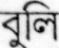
বুলি
